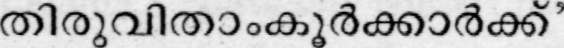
തിരുവിതാംകൂര്‍ക്കാര്‍ക്ക്'
